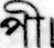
পী।
